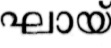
ഘായ്
